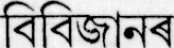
বিবিজানৰ
